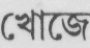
খোজে
